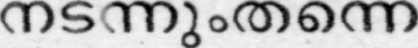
നടന്നുംതന്നെ
